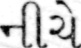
નીચે
